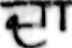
ਦਾ
